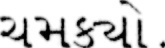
ચમક્યો.'
